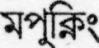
মপুক্নিং
